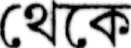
থেকে
